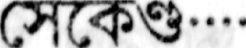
সেকেণ্ড...
